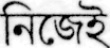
নিজেই
